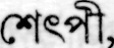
শেৎপী,
